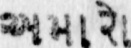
અમારો
